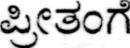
ಪ್ರೀತಂಗೆ
